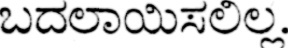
ಬದಲಾಯಿಸಲಿಲ್ಲ.
